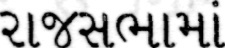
રાજસભામાં
